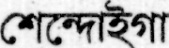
শেন্দোইগা
